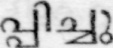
പ്പിച്ചു
